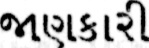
જાણકારી
